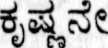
ಕೃಷ್ಣನೇ
